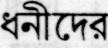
ধনীদের
